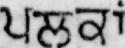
ਪਲਕਾ
